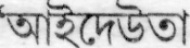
'আইদেউতা
